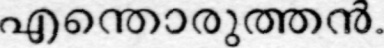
എന്തൊരുത്തന്‍.
